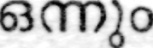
ഒന്നും
